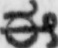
ಈ
